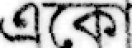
একো
